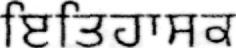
ਇਤਿਹਾਸਕ
